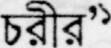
চরীর’১
